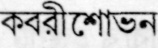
কবরীশোভন
